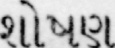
શોષણ
